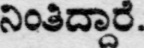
ನಿಂತಿದ್ದಾರೆ.
